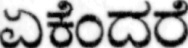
ಏಕೆಂದರೆ
